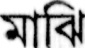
মাঝি
